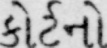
કોર્ટનો
